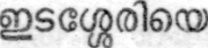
ഇടശ്ശേരിയെ
